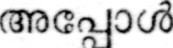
അപ്പോള്‍
